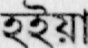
হইয়া
